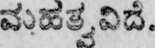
ಮಹತ್ವವಿದೆ.
